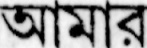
আমার
